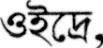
ওইদ্রে,
